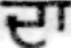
ਦਾ
